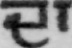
ਦਾ
